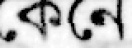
কেনে
